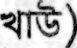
খাউ)
